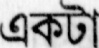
একটা
